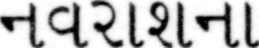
નવરાશના
